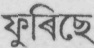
ফুৰিছে
